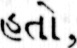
હતો,
